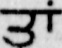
ਤਾਂ
